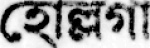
হোল্লগা
